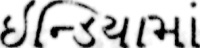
ઇન્ડિયામાં
